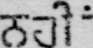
ਨਹੀਂ
